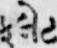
ફલેટ'
